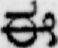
ಈ
